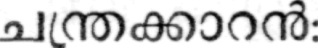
ചന്ത്രക്കാറന്‍:
